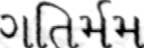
ગતિર્મમ
